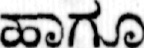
ಹಾಗೂ
